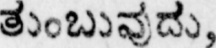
ತುಂಬುವುದು,
